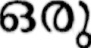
ഒരു
